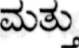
ಮತ್ತು
